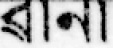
ৱানা
